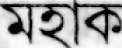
মহাক
